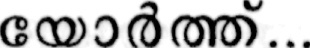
യോര്‍ത്ത്...
